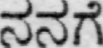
ನನಗೆ
